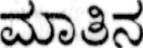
ಮಾತಿನ
